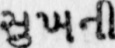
સુખની
